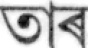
তাৰ
